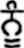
ਨੂੰ
